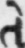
તે
